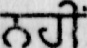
ਨਹੀਂ
